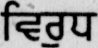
ਵਿਰੁਧ
